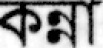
কন্না
